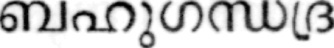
ബഹുഗന്ധദ്ര
